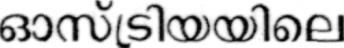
ഓസ്ട്രിയയിലെ
